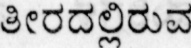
ತೀರದಲ್ಲಿರುವ
